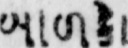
બાળકો
